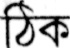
ঠিক
